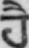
ਹੈ
